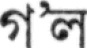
গ'ল
